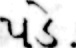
પડે.
